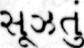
સૂઝતું
